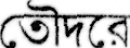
তৌদরে
